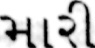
મારી
